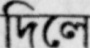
দিলে
